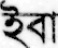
ইবা
